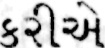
કરીએ
